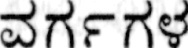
ವರ್ಗಗಳ
